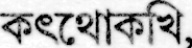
কৎথোকখি,
